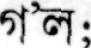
গ'ল;
